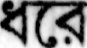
ধরে
